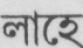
লাহে
